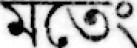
মতেং
